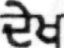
ਦੇਖ
